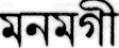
মনমগী
